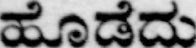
ಹೊಡೆದು
